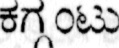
ಕಗ್ಗಂಟು
